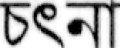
চৎনা
